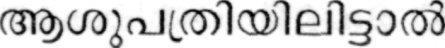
ആശുപത്രിയിലിട്ടാല്‍
